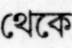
থেকে
